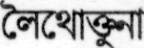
লৈথোক্তুনা
